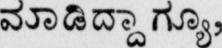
ಮಾಡಿದ್ದಾಗ್ಯೂ,
